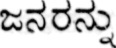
ಜನರನ್ನು
